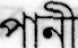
পানী
